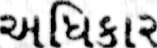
અધિકાર
